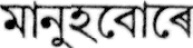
মানুহবোৰে
